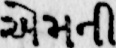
એમની
